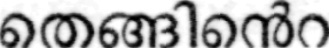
തെങ്ങിന്റെ
